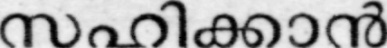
സഹിക്കാന്‍
